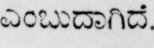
ಎಂಬುದಾಗಿದೆ.
